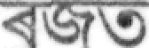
ৰজত
